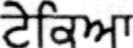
ਟੇਕਿਆ
